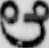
ಆ
